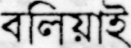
বলিয়াই
